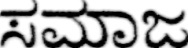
ಸಮಾಜ
